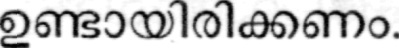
ഉണ്ടായിരിക്കണം.
